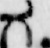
ಗ.
